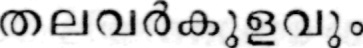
തലവര്‍കുളവും
